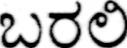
ಬರಲಿ
